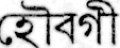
হৌবগী
